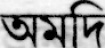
অমদি
